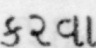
કરવા
